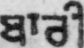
ਬਾਰੀ
